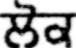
ਲੋਕ
